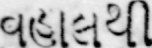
વહાલથી
